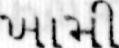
ખામી
